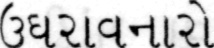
ઉઘરાવનારો
